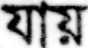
যায়
